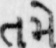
તમે
